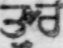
ਤੁਰ
